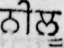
ਨੀਲੂ
